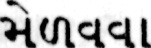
મેળવવા
